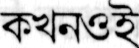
কখনওই
